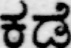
ಕಡೆ
